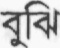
বুঝি
